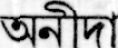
অনীদা
